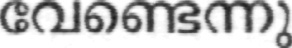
വേണ്ടെന്നു
